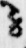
કે
